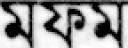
মফম
